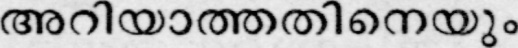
അറിയാത്തതിനെയും
